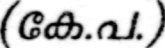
(കേ.പ.)
